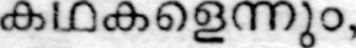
കഥകളെന്നും,
